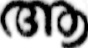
ആ
